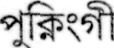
পুক্নিংগী
